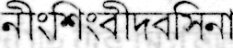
নীংশিংবীদবসিনা
